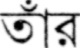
তাঁর
